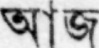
আজ
